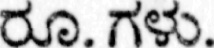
ರೂ.ಗಳು.
